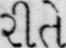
રીતે
